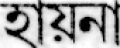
হায়না
